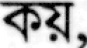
কয়,
